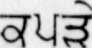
ਕਪੜੇ
